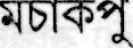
মচাকপু
